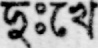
দুঃখে
